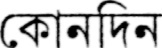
কোনদিন
